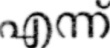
എന്ന്
